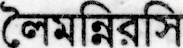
লৈমন্নিরসি
